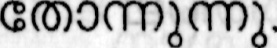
തോന്നുന്നു.
